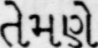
તેમણે
